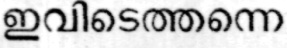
ഇവിടെത്തന്നെ
